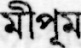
মীপূম
